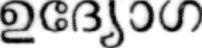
ഉദ്യോഗ
